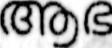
ആഭ
